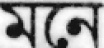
মনে
